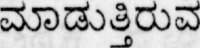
ಮಾಡುತ್ತಿರುವ
